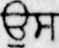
ਉਸ
